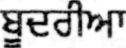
ਬੂਦਰੀਆ
